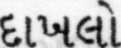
દાખલો
